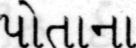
પોતાના
